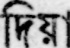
দিয়া
